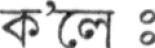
ক'লেঃ
